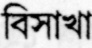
বিসাখা
